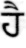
ਹੈ
